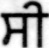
ਸੀ
